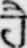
ਹੈ
